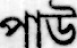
পাউ
